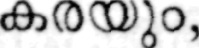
കരയും,
